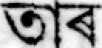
তাৰ
